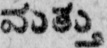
ಮತ್ತು
